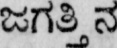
ಜಗತ್ತಿನ
